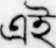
এই
